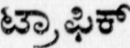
ಟ್ರಾಫಿಕ್
